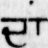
ਦਾ
